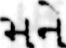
મને
